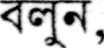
বলুন,
